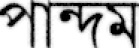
পান্দম
